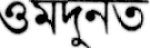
ওমদুনত
